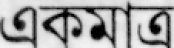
একমাত্র
